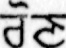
ਰੋਣ
